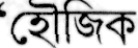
‘হৌজিক
